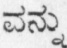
ವನ್ನು
